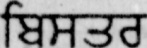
ਬਿਸਤਰ
